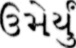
ઉમેર્યું
